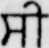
ਸੀ
